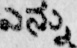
ಎನ್ನು
